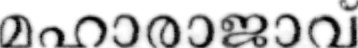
മഹാരാജാവ്
